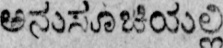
ಅನುಸೂಚಿಯಲ್ಲಿ
